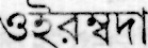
ওইরম্বদা
